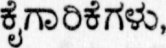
ಕೈಗಾರಿಕೆಗಳು,
